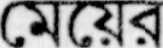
মেয়ের
